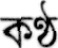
কণ্ঠ
